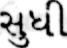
સુધી
